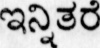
ಇನ್ನಿತರೆ
